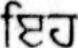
ਇਹ
